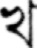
খ
